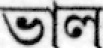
ভাল
